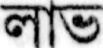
লাভ
